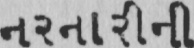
નરનારીની
